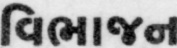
વિભાજન
